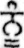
ਨੂੰ
